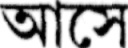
আসে
